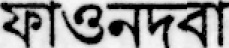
ফাওনদবা
